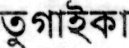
তুগাইকা
